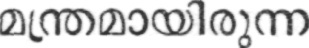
മന്ത്രമായിരുന്ന
